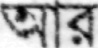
আর
